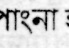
পাংনা
